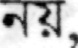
নয়,
